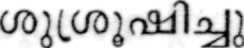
ശുശ്രൂഷിച്ചു
